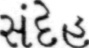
સંદેહ
